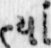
ત્યાં
